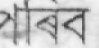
পৰিব
